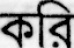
করি
